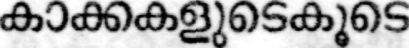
കാക്കകളുടെകൂടെ
